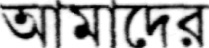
আমাদের
